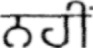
ਨਹੀਂ
